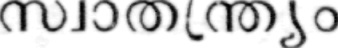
സ്വാതന്ത്ര്യം
